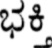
ಭಕ್ತಿ
